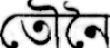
তৌনৈ
